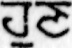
ਹੁਣ
